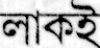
লাকই
